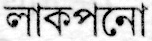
লাকপনো
